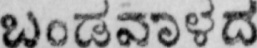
ಬಂಡವಾಳದ
